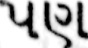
પણ
